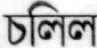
চলিল
